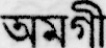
অমগী
